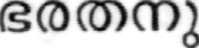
ഭരതനു
